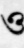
ও
